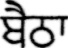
ਬੈਠਾ
